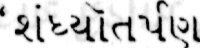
શંધ્યૉતર્પણ
